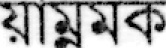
য়াম্নমক
